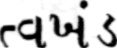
ત્વખંડ
